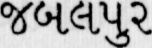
જબલપુર
